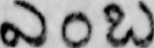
ಎಂಬ
